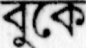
বুকে
